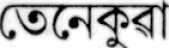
তেনেকুৱা
